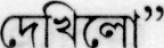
দেখিলো"
